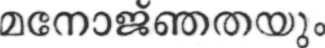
മനോജ്ഞതയും
